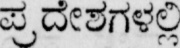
ಪ್ರದೇಶಗಳಲ್ಲಿ
